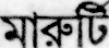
মারুটি
